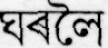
ঘৰলৈ
